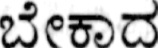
ಬೇಕಾದ
